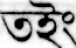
তইং
